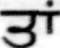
ਤਾਂ
